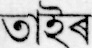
তাইৰ
